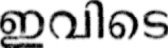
ഇവിടെ
